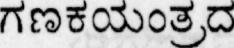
ಗಣಕಯಂತ್ರದ
